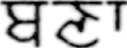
ਬਣਾ
